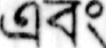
এবং
